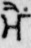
ਮੈਂ
